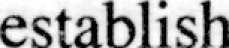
establish
